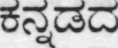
ಕನ್ನಡದ
